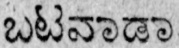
ಬಟವಾಡಾ
